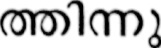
ത്തിന്നു
